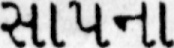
સાપના
